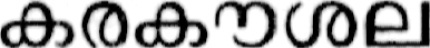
കരകൌശല
